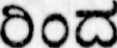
ರಿಂದ
